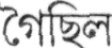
গৈছিল
